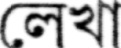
লেখা
